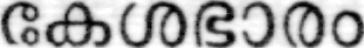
കേശഭാരം
